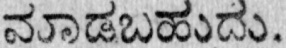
ಮಾಡಬಹುದು.
